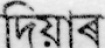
দিয়াৰ
